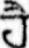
ਹੈ
